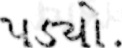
પડ્યો.
